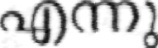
എന്നു
